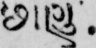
છાણું.
